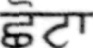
ਛੋਟਾ
